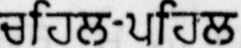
ਚਹਿਲ-ਪਹਿਲ
